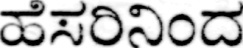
ಹೆಸರಿನಿಂದ
